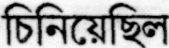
চিনিয়েছিল
